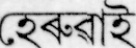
হেৰুৱাই
